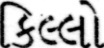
કિલ્લો
